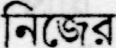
নিজের
